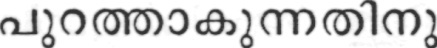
പുറത്താകുന്നതിനു
